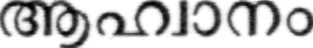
ആഹ്വാനം
